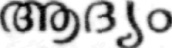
ആദ്യം
